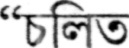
“চলিত
